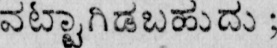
ವಟ್ಟಾಗಿಡಬಹುದು;
